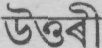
উত্তৰী
